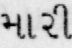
મારી
